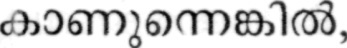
കാണുന്നെങ്കില്‍,
